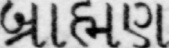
બ્રાહ્મણ
